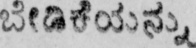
ಬೇಡಿಕಯನ್ನು
